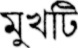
মুখটি
